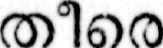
തീരെ
